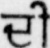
ਦੀ
